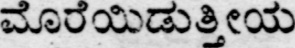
ಮೊರೆಯಿಡುತ್ತೀಯ
